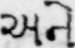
અને
